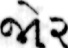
જોર
